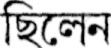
ছিলেন
